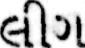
લીગ
